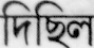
দিছিল
